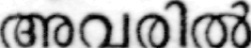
അവരില്‍
